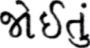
જોઈતું
